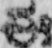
ಈ
